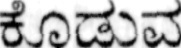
ಕೊಡುವ
